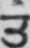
ਤੇ
